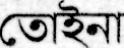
তোইনা
